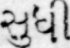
સુધી
